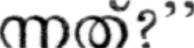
ന്നത്?"
